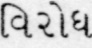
વિરોધ
